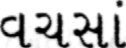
વચસાં
